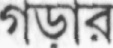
গড়ার
